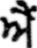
ਐਂ
